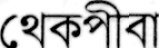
থেকপীবা
